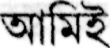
আমিই
